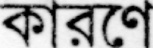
কারণে
